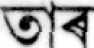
তাৰ
